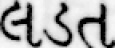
લડત
